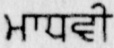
ਮਾਧਵੀ
